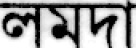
লমদা
